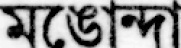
মঙোন্দা
